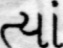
ત્યાં
